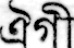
ঐগী
